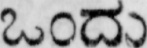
ಒಂದು
